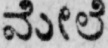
ಮೇಲೆ
